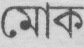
মোক
